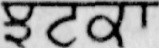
ਝਟਕਾ
